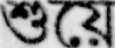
শুয়ে
